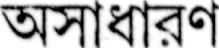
অসাধারণ
